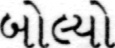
બોલ્યો
